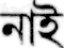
নাই
